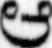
ಆ
